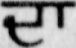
ਦਾ
